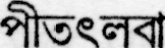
পীতৎলবা
